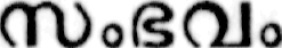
സംഭവം
